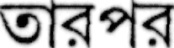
তারপর
